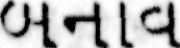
બનાવ
